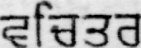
ਵਚਿਤਰ
